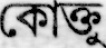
কোক্তু
